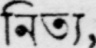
নিত্য,
